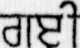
ਗਈ
